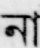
না
